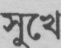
সুখে
